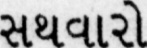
સથવારો
